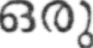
ഒരു
